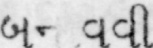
બનાવવી
